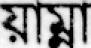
য়াম্না
